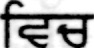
ਵਿਚ
